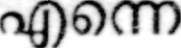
എന്നെ
